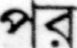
পর
